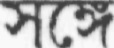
সঙ্গে
